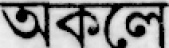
অকলে
